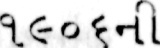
૧૯૦૬ની
